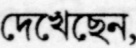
দেখেছেন,
